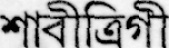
শাবীত্রিগী
